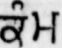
ਕੰਮ
